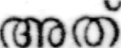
അത്
